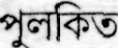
পুলকিত
